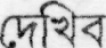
দেখিব
